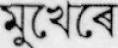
মুখেৰে
